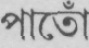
পাতোঁ
